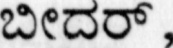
ಬೀದರ್,
